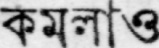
কমলাও
